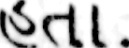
હતા.
